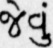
જેવું
